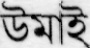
উমাই
